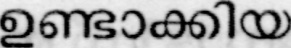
ഉണ്ടാക്കിയ
